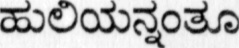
ಹುಲಿಯನ್ನಂತೂ
